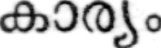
കാര്യം
